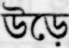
উড়ে
